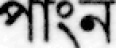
পাংন
